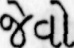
જેવો
